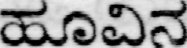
ಹೂವಿನ
